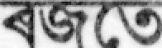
ৰজতে
